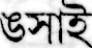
ঙসাই
